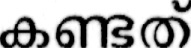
കണ്ടത്
